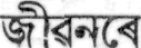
জীৱনৰে
